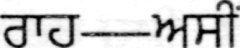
ਰਾਹ-ਅਸੀਂ
